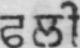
ਫਲੀ
